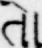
તો
